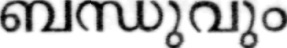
ബന്ധുവും
